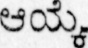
ಆಯ್ಕೆ
